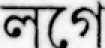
লগে
